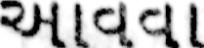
આવવા
